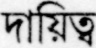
দায়িত্ব
